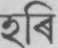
হৰি
